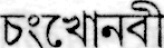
চংখোনবী
